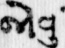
જોવું
